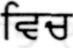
ਵਿਚ
